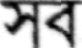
সব
